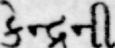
કેન્દ્રની
